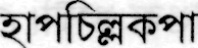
হাপচিল্লকপা
